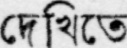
দেখিতে
